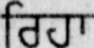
ਰਿਹਾ
